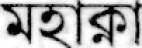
মহাক্না
